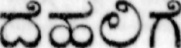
ದೆಹಲಿಗೆ
